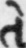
તે
